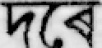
দৰে
